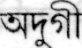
অদুগী
